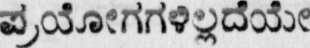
ಪ್ರಯೋಗಗಳಿಲ್ಲದೆಯೇ
